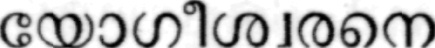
യോഗീശ്വരനെ
